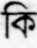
কি
